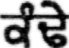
ਕੰਢੇ
